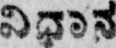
ವಿಧಾನ
